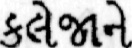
કલેજાને
